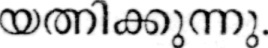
യത്നിക്കുന്നു.
